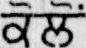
ਕੋਲੋਂ
